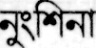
নুংশিনা
